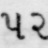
પર
